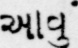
આવું
